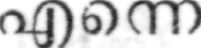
എന്നെ
